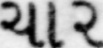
ચાર
